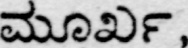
ಮೂರ್ಖ,
